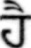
ਹੈ
